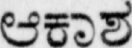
ಆಕಾಶ
